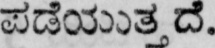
ಪಡೆಯುತ್ತದೆ.
